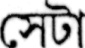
সেটা
